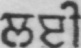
ਲਈ
